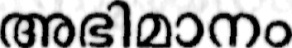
അഭിമാനം
